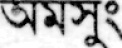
অমসুং
